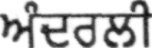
ਅੰਦਰਲੀ
